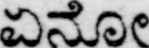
ಏನೋ
